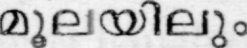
മൂലയിലും
